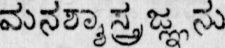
ಮನಶ್ಯಾಸ್ತ್ರಜ್ಞನು
